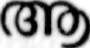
ആ
